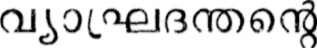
വ്യാഘ്രദന്തന്റെ
